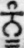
ਨੂੰ
